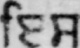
ਇਸ
